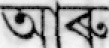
আৰু
